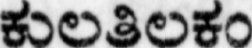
ಕುಲತಿಲಕಂ
